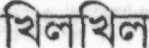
খিলখিল
